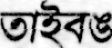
তাইবঙ
